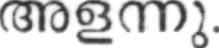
അളന്നു.
